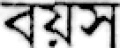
বয়স
